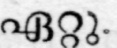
ഏറ്റു.
